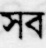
সব
